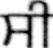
ਸੀ
